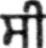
ਸੀ
